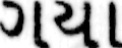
ગયા
